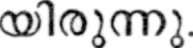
യിരുന്നു.
